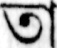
তা
